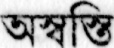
অস্বস্তি
